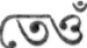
তেওঁ
